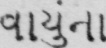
વાયુંના
